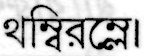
থম্বিরম্লে।
